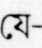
যে-
